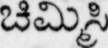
ಚಿಮ್ಮಿಸಿ
